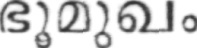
ഭൂമുഖം
